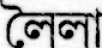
লৈলা
